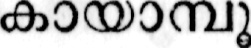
കായാമ്പൂ
